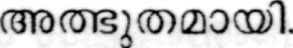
അത്ഭുതമായി.
